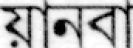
য়ানবা
